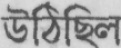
উঠিছিল
